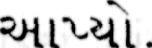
આપ્યો.
